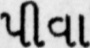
પીવા
